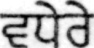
ਵਧੇਰੇ
